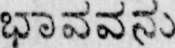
ಭಾವವನು
